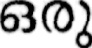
ഒരു
